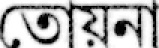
তোয়না
